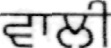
ਵਾਲੀ
